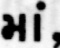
માં,
